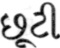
છૂટી
